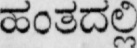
ಹಂತದಲ್ಲಿ
